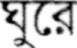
ঘুরে
